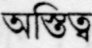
অস্তিত্ব
